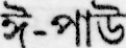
ঈ-পাউ
